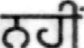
ਨਹੀਂ
